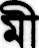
মী
